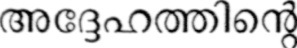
അദ്ദേഹത്തിന്റെ
